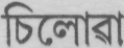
চিলোৱা
